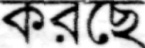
করছে
